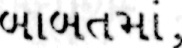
બાબતમાં,
